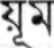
য়ূম
